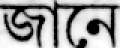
জানে
